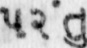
પરંતુ
